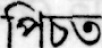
পিচত
